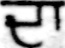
ਦਾ
